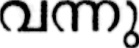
വന്നു
